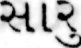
સારુ
